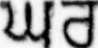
ਘਰ
